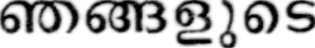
ഞങ്ങളുടെ
